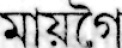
মায়গৈ
